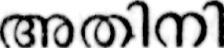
അതിനി
